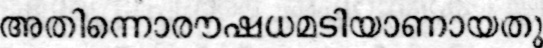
അതിന്നൊരൗഷധമടിയാണായതു
